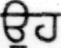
ਉਹ
